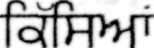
ਕਿੱਸਿਆਂ
